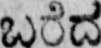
ಬರೆದ
